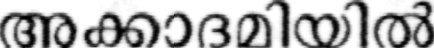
അക്കാദമിയില്‍
